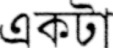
একটা
